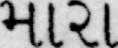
મારા
